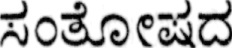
ಸಂತೋಷದ
